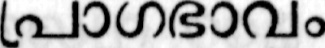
പ്രാഗഭാവം
